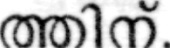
ത്തിന്.
